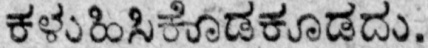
ಕಳುಹಿಸಿಕೊಡಕೂಡದು.
